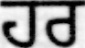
ਹਰ
